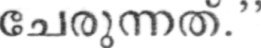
ചേരുന്നത്."
